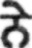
ਨੇ
